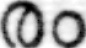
രം
